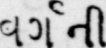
વર્ગની
